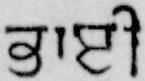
ਭਾਈ
